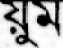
য়ুম
